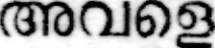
അവളെ
